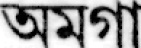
অমগা
